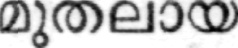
മുതലായ
